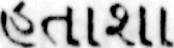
હતાશા
